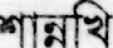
শান্নখি
